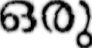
ഒരു
